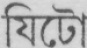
যিটো
